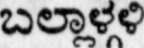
ಬಲ್ಲಾಳ್ಗಲಿ
